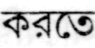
করতে
